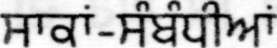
ਸਾਕਾਂ-ਸੰਬੰਧੀਆਂ
